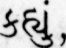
કહ્યું,
